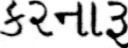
કરનારૂ
